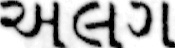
અલગ
